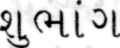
શુભાંગ
